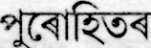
পুৰোহিতৰ
